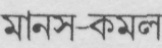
মানস-কমল
